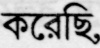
করেছি,
